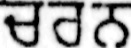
ਚਰਨ
